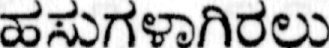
ಹಸುಗಳಾಗಿರಲು
